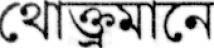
থোক্ত্রমানে
